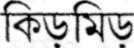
কিড়মিড়
